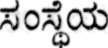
ಸಂಸ್ಥೆಯ
